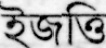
ইজত্তি
